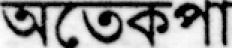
অতেকপা
